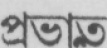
প্ৰভাত
